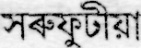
সৰুফুটীয়া
